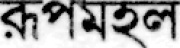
রূপমহল
